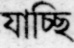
যাচ্ছি
